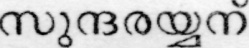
സുന്ദരയ്യന്
